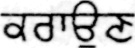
ਕਰਾਉਣ
